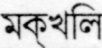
মক্খলি
